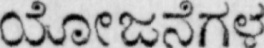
ಯೋಜನೆಗಳ
